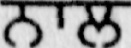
ਨਾਲ
